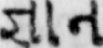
જ્ઞાન
